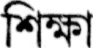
শিক্ষা
